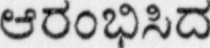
ಆರಂಭಿಸಿದ
